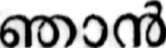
ഞാന്‍
